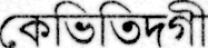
কেভিতিদগী
